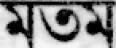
মতম
